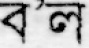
ব'ল
